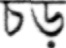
চড়
